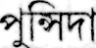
পুন্সিদা
